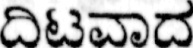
ದಿಟವಾದ
